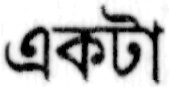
একটা
